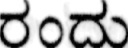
ರಂದು
